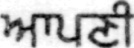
ਆਪਣੀ
